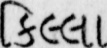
કિલ્લા
